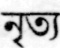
নৃত্য
